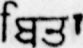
ਬਿਤਾ
